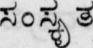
ಸಂಸ್ಕೃತ
